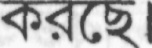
করছে।
